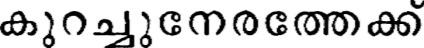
കുറച്ചുനേരത്തേക്ക്
